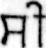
ਸੀ
